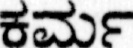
ಕರ್ಮ
